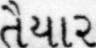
તૈયાર
